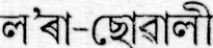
ল'ৰা-ছোৱালী
